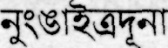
নুংঙাইত্রদূনা
